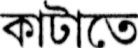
কাটাতে
